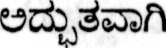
ಅದ್ಭುತವಾಗಿ
